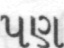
પણ
